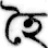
হৈ
